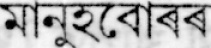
মানুহবোৰৰ
